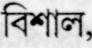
বিশাল,
